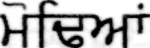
ਮੋਢਿਆਂ
